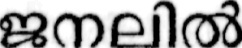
ജനലില്‍
